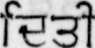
ਦਿਤੀ
